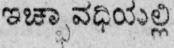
ಇಚ್ಛಾವಧಿಯಲ್ಲಿ
